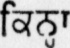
ਕਿਨ੍ਹਾ
